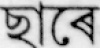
ছাৰে
